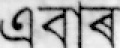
এবাৰ
